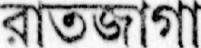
রাতজাগা
